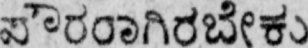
ಪೌರರಾಗಿರಬೇಕು
